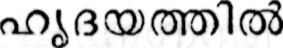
ഹൃദയത്തില്‍
